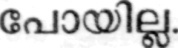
പോയില്ല.
